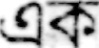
এক
